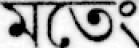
মতেং
